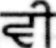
ਵੀ
